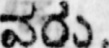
ವರು.
